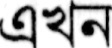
এখন
